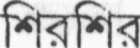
শিরশির
